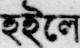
হইলে
